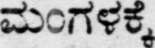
ಮಂಗಳಕ್ಕೆ
